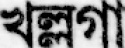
খল্লগা
